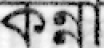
কন্না
